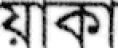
য়াকা
